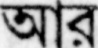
আর
